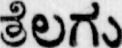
ತೆಲಗು
